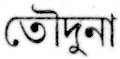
তৌদুনা
